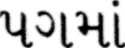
પગમાં
